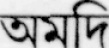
অমদি
